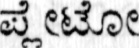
ಪ್ಲೇಟೋ
